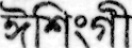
ঈশিংগী
